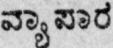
ವ್ಯಾಪಾರ
